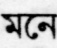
মনে
